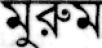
মুরুম
